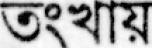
তংখায়
